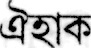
ঐহাক
